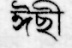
ঈছী
